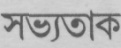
সভ্যতাক
